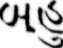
બહુ
